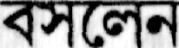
বসলেন
